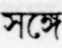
সঙ্গে
